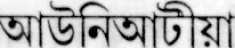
আউনিআটীয়া
